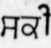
ਸਕੀ
